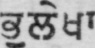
ਭੁਲੇਖਾ
